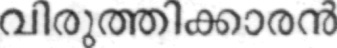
വിരുത്തിക്കാരന്‍
